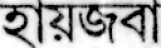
হায়জবা
